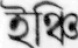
ইঞ্চি
